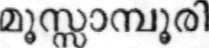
മൂസ്സാമ്പൂരി
